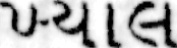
ખ્યાલ
